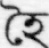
হৈ
